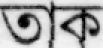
তাক
